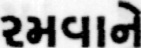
રમવાને
